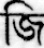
জি
